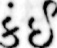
કંઇ
